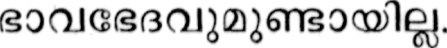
ഭാവഭേദവുമുണ്ടായില്ല.
